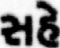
સહે
